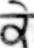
ਕੇ
